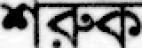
শরুক
